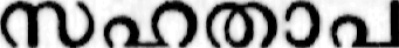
സഹതാപ
